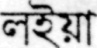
লইয়া
